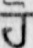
ਹੋ
